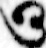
ও
